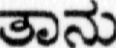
ತಾನು
